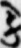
કે
